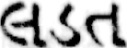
લડત
